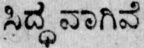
ಸಿದ್ಧವಾಗಿವೆ
